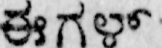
ಈಗಳ್
